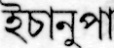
ইচানুপা
